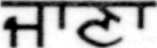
ਜਾਣਾ
